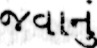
જવાનું
